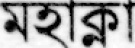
মহাক্না
